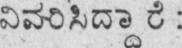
ವಿವರಿಸಿದ್ದಾರೆ:
